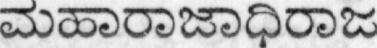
ಮಹಾರಾಜಾಧಿರಾಜ
